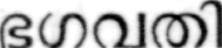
ഭഗവതി
